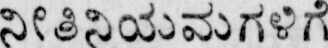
ನೀತಿನಿಯಮಗಳಿಗೆ
